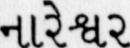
નારેશ્વર
